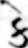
કે
